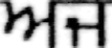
ਅਜ
